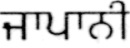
ਜਾਪਾਨੀ
